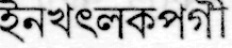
ইনখৎলকপগী
